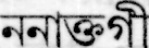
ননাক্তগী
